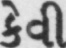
કેવી
